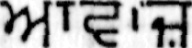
ਆਵਾਜ਼
